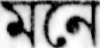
মনে
